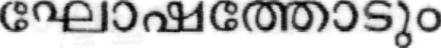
ഘോഷത്തോടും
